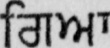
ਗਿਆ
